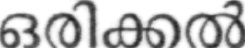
ഒരിക്കല്‍
